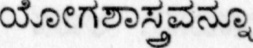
ಯೋಗಶಾಸ್ತ್ರವನ್ನೂ
